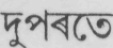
দুপৰতে
